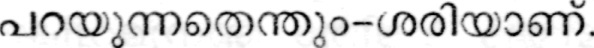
പറയുന്നതെന്തും-ശരിയാണ്.
